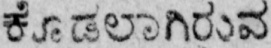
ಕೊಡಲಾಗಿರುವ
